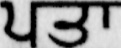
ਪਤਾ
